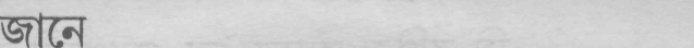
জানে
